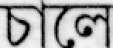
চালে
